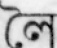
লৈ
